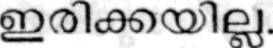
ഇരിക്കയില്ല.
